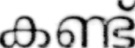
കണ്ട്
